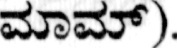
ಮಾಮ್).
